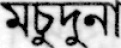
মচুদুনা
